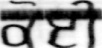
ਕੋਈ
